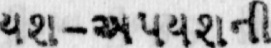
યશ-અપયશની
